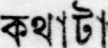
কথাটা
